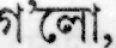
গ'লো,
